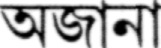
অজানা
